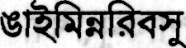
ঙাইমিন্নরিবসু
